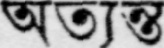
অত্যন্ত
